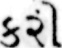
કરી
